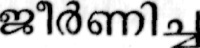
ജീര്‍ണിച്ച
